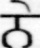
ਨੇ
